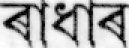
ৰাধাৰ
